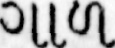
ગાળ
